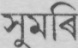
সুমৰি
